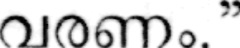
വരണം."
